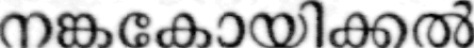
നങ്കകോയിക്കല്‍
